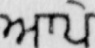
ਆਪੇ
